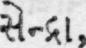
સેન્દ્રા,
